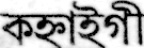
কহ্নাইগী
